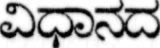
ವಿಧಾನದ
